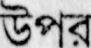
উপর
